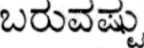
ಬರುವಷ್ಟು
